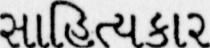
સાહિત્યકાર
